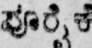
ಪೂರೈಕೆ
